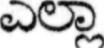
ಎಲ್ಲಾ
